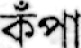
কঁপা
